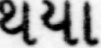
થયા
